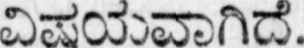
ವಿಷಯವಾಗಿದೆ.
